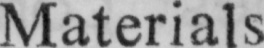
Materials
